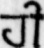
ਹੀ
